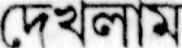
দেখলাম
